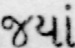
જ્યાં
